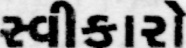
સ્વીકારો
